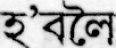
হ'বলৈ
